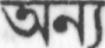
অন্য
